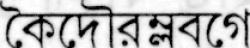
কৈদৌরম্লবগে
